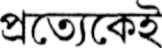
প্রত্যেকেই
